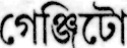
গেঞ্জিটো
